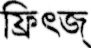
ফ্রিৎজ্
